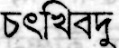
চৎখিবদু
